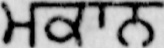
ਮਕਾਨ
